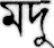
মদু
